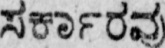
ಸರ್ಕಾರವು
